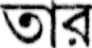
তার
